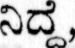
ನಿದ್ದೆ,
